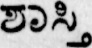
ಶಾಸ್ತಿ
